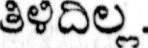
ತಿಳಿದಿಲ್ಲ.
